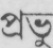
প্ৰভু
